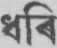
ধৰি
